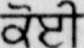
ਕੋਈ
